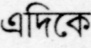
এদিকে
